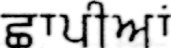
ਛਾਪੀਆਂ
